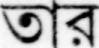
তার
